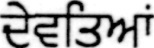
ਦੇਵਤਿਆਂ
